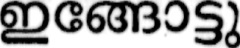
ഇങ്ങോട്ടു
